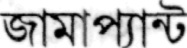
জামাপ্যান্ট
